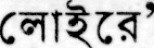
লোইরে’
